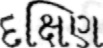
દક્ષિણ
